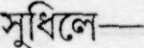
সুধিলে-
